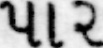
પાર
